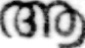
ആ
